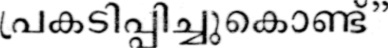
പ്രകടിപ്പിച്ചുകൊണ്ട്"
